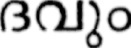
ദവും
